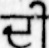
ਦੀ
